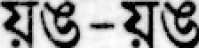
য়ঙ-য়ঙ
